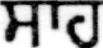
ਸਾਹ
